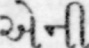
એની
